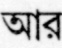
আর
